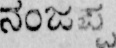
ನಂಜಪ್ಪ
